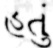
હતું
